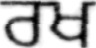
ਰਖ
